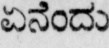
ಏನೆಂದು
